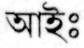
আইঃ
